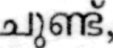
ചുണ്ട്,
